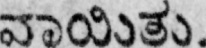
ವಾಯಿತು.
